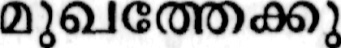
മുഖത്തേക്കു
